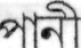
পানী
